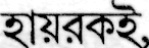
হায়রকই,
